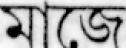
মাজে
